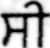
ਸੀ
